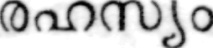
രഹസ്യം
